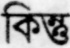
কিন্তু
